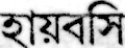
হায়বসি
